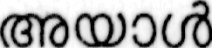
അയാള്‍
